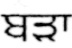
ਬੜਾ
